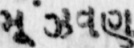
મૂંઝવણ
